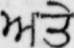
ਅਤੇ
